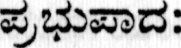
ಪ್ರಭುಪಾದ:
